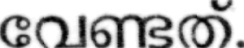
വേണ്ടത്.
